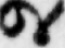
જ
